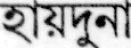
হায়দুনা
